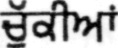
ਚੁੱਕੀਆਂ
